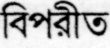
বিপরীত
